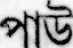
পাউ
